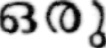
ഒരു
